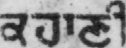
ਕਹਾਣੀ
